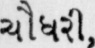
ચૌધરી,
